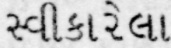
સ્વીકારેલા
